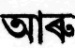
আৰু
